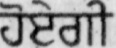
ਹੋਏਗੀ
